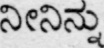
ನೀನಿನ್ನು
